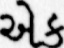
એક
